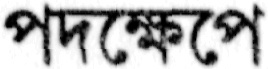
পদক্ষেপে
